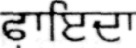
ਫ਼ਾਇਦਾ
